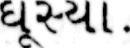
ઘૂસ્યા.
